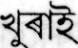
খুৰাই
